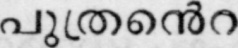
പുത്രന്റെ
